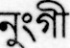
নুংগী
